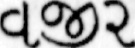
વજીર
